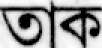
তাক
